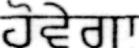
ਹੋਵੇਗਾ
